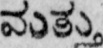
ಮತ್ತು
